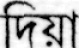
দিয়া
